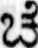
ಚೆ
